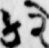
કરે
